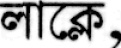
লাক্লে,
